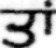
ਤਾਂ
